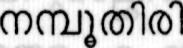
നമ്പൂതിരി
